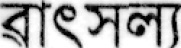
ৱাৎসল্য
